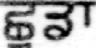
ਛੁਡਾ
